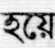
হয়ে
